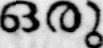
ഒരു
